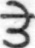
ਤੇ
